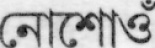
নোশোওঁ
